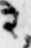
રે
